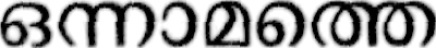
ഒന്നാമത്തെ
